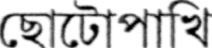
ছোটোপাখি
